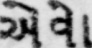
એવો
